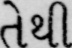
તેથી
